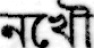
নখৌ
